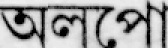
অলপো
